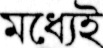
মধ্যেই
